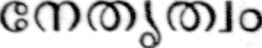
നേതൃത്വം
